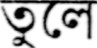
তুলে
